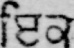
ਇਕ
